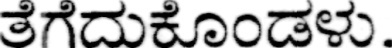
ತೆಗೆದುಕೊಂಡಳು.
